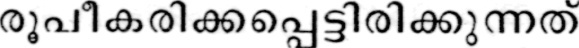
രൂപീകരിക്കപ്പെട്ടിരിക്കുന്നത്
